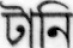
টানি
